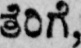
ತೆರಿಗೆ,
